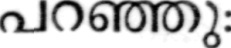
പറഞ്ഞു:
